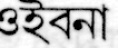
ওইবনা
